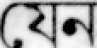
যেন
